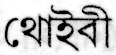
থোইবী
